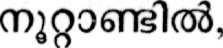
നൂറ്റാണ്ടില്‍,
